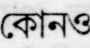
কোনও
